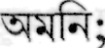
অমনি;
